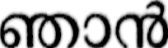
ഞാന്‍
